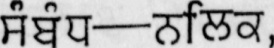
ਸੰਬੰਧ---ਨਲਿਕ,
